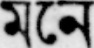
মনে
